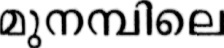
മുനമ്പിലെ
